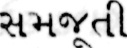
સમજૂતી
